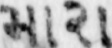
મારા
